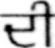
ਦੀ
